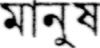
মানুষ
